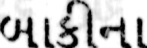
બાકીના
